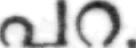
പറ.
